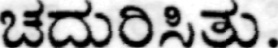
ಚದುರಿಸಿತು.
